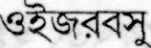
ওইজরবসু
